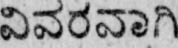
ವಿವರವಾಗಿ
